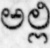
ಅಲ್ಲಿ
